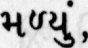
મળ્યું,
